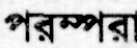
পরম্পরা
